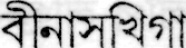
বীনাসখিগা
